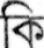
কি
